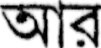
আর
